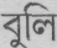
বুলি
